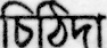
চিঠিদা
